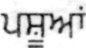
ਪਸ਼ੂਆਂ
